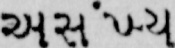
અસંખ્ય
